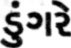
ડુંગરે
